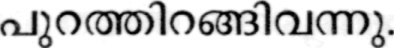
പുറത്തിറങ്ങിവന്നു.
